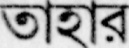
তাহার
